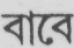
বাবে
